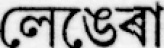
লেঙেৰা
